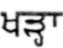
ਖੜ੍ਹਾ
